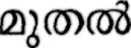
മുതല്‍
